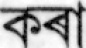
কৰা
